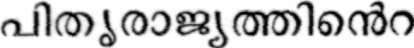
പിതൃരാജ്യത്തിന്റെ
